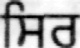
ਸਿਰ
